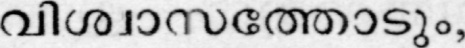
വിശ്വാസത്തോടും,
